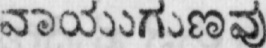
ವಾಯುಗುಣವು
